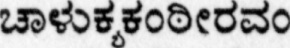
ಚಾಳುಕ್ಯಕಂಠೀರವಂ
